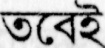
তবেই
